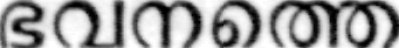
ഭവനത്തെ
